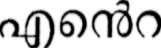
എന്റെ
